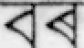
বৰ
